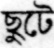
ছুটে
